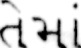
તેમાં
